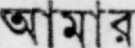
আমার
